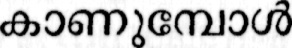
കാണുമ്പോള്‍
